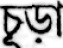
চূড়া
